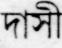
দাসী
